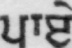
ਪਾਏ
